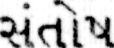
સંતોષ
